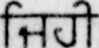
ਜਿਹੀ
